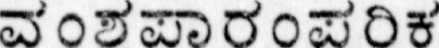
ವಂಶಪಾರಂಪರಿಕ
